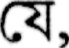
যে,
